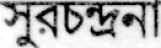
সুরচন্দ্রনা
